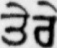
ਤੇਰੇ
